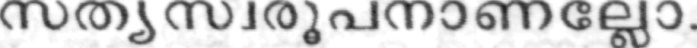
സത്യസ്വരൂപനാണല്ലോ.
